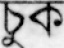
চুক
